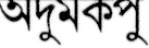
অদুমকপু
